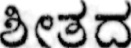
ಶೀತದ
